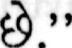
છે."
